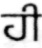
ਹੀ
